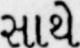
સાથે
